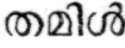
തമിള്‍
